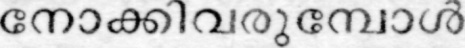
നോക്കിവരുമ്പോള്‍
